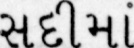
સદીમાં
